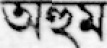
অহুম
